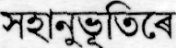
সহানুভূতিৰে
